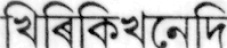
খিৰিকিখনেদি
